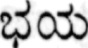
ಭಯ
